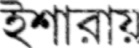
ইশারায়
